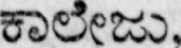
ಕಾಲೇಜು,
